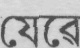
যেৱে
